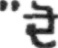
''ਦੋ
